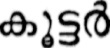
കൂട്ടര്‍
